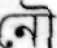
নৌ
